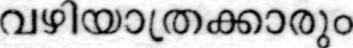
വഴിയാത്രക്കാരും
